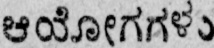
ಆಯೋಗಗಳು
